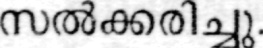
സല്‍ക്കരിച്ചു.
